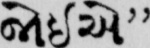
જોઈએ”
